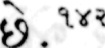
છે.૧૪૨
